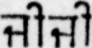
ਜੀਜੀ
